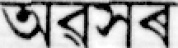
অৱসৰ
